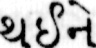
થઈને
